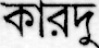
কারদু
